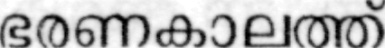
ഭരണകാലത്ത്
